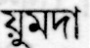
য়ুমদা
